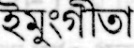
ইমুংগীতা
